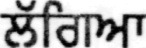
ਲੱਗਿਆ
